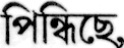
পিন্ধিছে,
